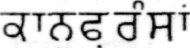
ਕਾਨਫ਼ਰੰਸਾਂ
